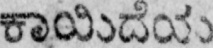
ಕಾಯಿದೆಯ
